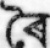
ৰৈ
